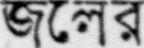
জলের
